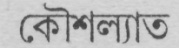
কৌশল্যাত
